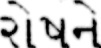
રોષને
